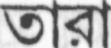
তারা
